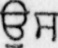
ਉਸ
